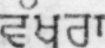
ਵੱਖਰਾ
